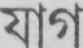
যাগ
